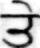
ਤੇ
